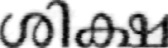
ശിക്ഷ
